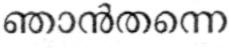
ഞാന്‍തന്നെ
